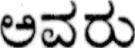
ಅವರು
